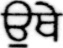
ਉਥੇ
